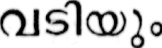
വടിയും
